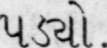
પડયો.
